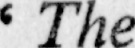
‘The
